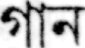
গান
